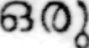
ഒരു
